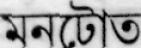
মনটোত
